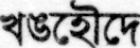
খঙহৌদে
